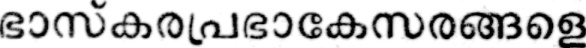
ഭാസ്കരപ്രഭാകേസരങ്ങളെ
